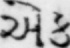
એક
